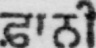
ਫ਼ਾਨੀ
